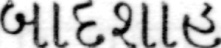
બાદશાહ
